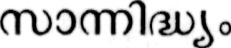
സാന്നിദ്ധ്യം
